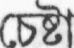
চেষ্টা
